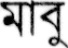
মাবু
